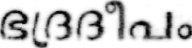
ഭദ്രദീപം
